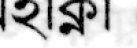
মহাক্না
